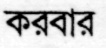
করবার
